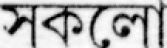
সকলো
